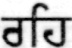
ਰਹਿ
